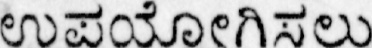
ಉಪಯೋಗಿಸಲು
